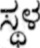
ಸ್ಥಳ
